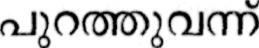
പുറത്തുവന്ന്
